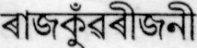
ৰাজকুঁৱৰীজনী
